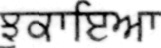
ਝੁਕਾਇਆ
